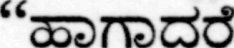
“ಹಾಗಾದರೆ
